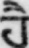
ਹੈ
